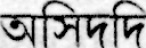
অসিদদি
